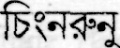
চিংনরুনু
